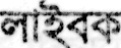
লাইবক
